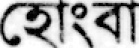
হোংবা
